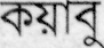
কয়াবু
